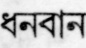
ধনবান
